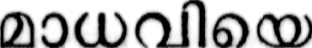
മാധവിയെ
